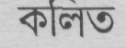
কলিত
